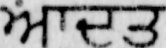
ਆਦਤ
